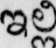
ಇಲ್ಲಿ
